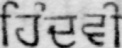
ਹਿੰਦਵੀ
